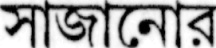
সাজানোর
